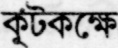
কুটকক্ষে
